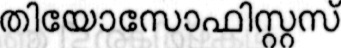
തിയോസോഫിസ്റ്റസ്
